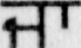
ਜਾ
